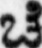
ಚೆ
